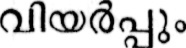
വിയര്‍പ്പും
